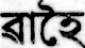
ৱাহৈ
